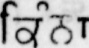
ਕਿੰਨਾ
